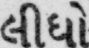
લીધો
